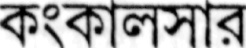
কংকালসার
